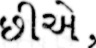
છીએ,
